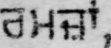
ਰਮਜ਼ਾਂ,
